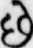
છે
